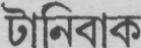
টানিবাক
